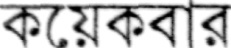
কয়েকবার
